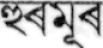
হুৰমূৰ
